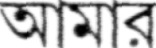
আমার
